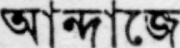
আন্দাজে
